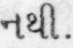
નથી.
